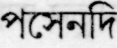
পসেনদি
